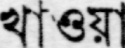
খাওয়া
